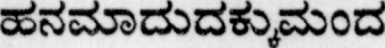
ಹನಮಾದುದಕ್ಕುಮಂದ
